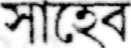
সাহেব
